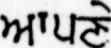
ਆਪਣੇ
